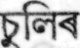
চুলিৰ
